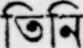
তিনি
